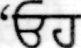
'ਓਹ
